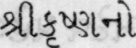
શ્રીકૃષ્ણનો
